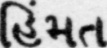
હિંમત
